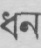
ধন
